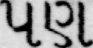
પણ
